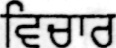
ਵਿਚਾਰ
